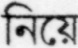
নিয়ে
